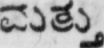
ಮತ್ತು
